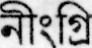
নীংগ্রি
